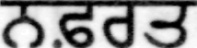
ਨਫ਼ਰਤ
